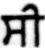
ਸੀ
